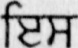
ਇਸ
